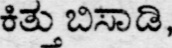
ಕಿತ್ತುಬಿಸಾಡಿ,
